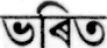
ভৰিত
